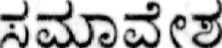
ಸಮಾವೇಶ
